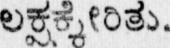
ಲಕ್ಷಕ್ಕೇರಿತು.
